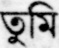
তুমি
